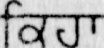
ਕਿਹਾ
